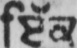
ਇੱਕ
